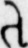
તે
